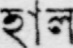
হাল
